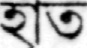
হাত
